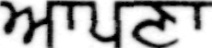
ਆਪਣਾ
